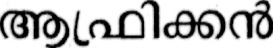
ആഫ്രിക്കന്‍
